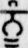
ਨੂੰ
